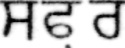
ਸਫ਼ਰ
